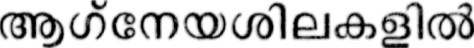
ആഗ്നേയശിലകളില്‍
